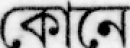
কোনে
